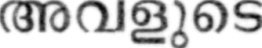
അവളുടെ
